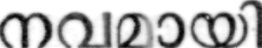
നവമായി
